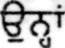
ਉਨ੍ਹਾਂ
